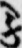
કે
